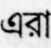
এরা
